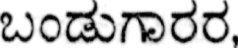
ಬಂಡುಗಾರರ,
